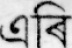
এৰি
